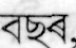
বছৰ,
